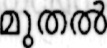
മുതല്‍
